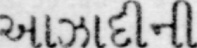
આઝાદીની
